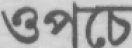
ওপচে
